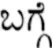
ಬಗ್ಗೆ
